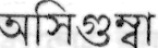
অসিগুম্বা
